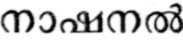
നാഷനല്‍
